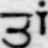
ਤਾਂ
